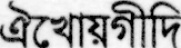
ঐখোয়গীদি
